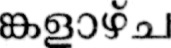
ങ്കളാഴ്ച
